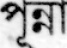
পূন্না
